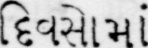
દિવસોમાં
